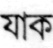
যাক
